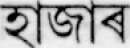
হাজাৰ
